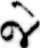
જે
